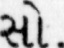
સો.
